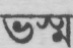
ভস্ম
